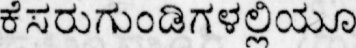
ಕೆಸರುಗುಂಡಿಗಳಲ್ಲಿಯೂ
